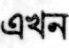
এখন
